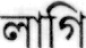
লাগি
